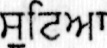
ਸੁਟਿਆ
